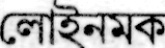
লোইনমক
